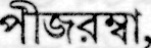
পীজরম্বা,
